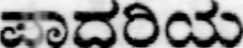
ಪಾದರಿಯ
